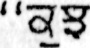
''ਕੁਝ
